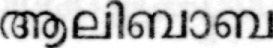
ആലിബാബ
